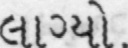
લાગ્યો.
